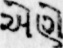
એણે
